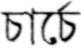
চার্চে
